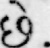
છે.
